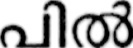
പില്‍
